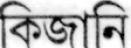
কিজানি
